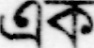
এক
